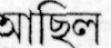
আছিল
